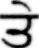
ਤੇ
